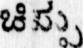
ಚಿಪ್ಪು
